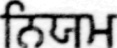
ਨਿਯਮ
